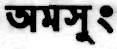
অমসুং
